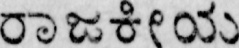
ರಾಜಕೀಯ
